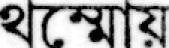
থম্মোয়
